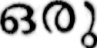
ഒരു
